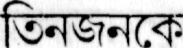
তিনজনকে
